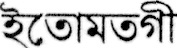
ইতোমতগী
